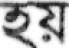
হয়
